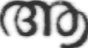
ആ
